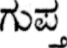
ಗುಪ್ತ
